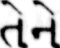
તેને
